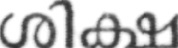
ശിക്ഷ
